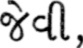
જેવી,
